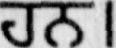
ਹਨ।
